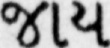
જાય
